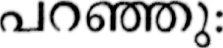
പറഞ്ഞു:
